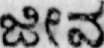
ಜೀವ
